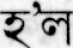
হ'ল
